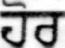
ਹੋਰ
